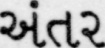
અંતર
